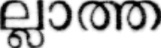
ല്ലാത്ത
